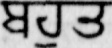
ਬਹੁਤ
